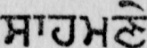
ਸਾਹਮਣੇ
